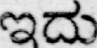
ಇದು
